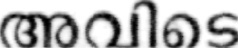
അവിടെ
